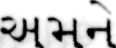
અમને
